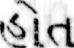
હોત
